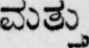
ಮತ್ತು
